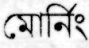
মোর্নিং
